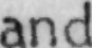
and
